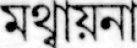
মথ্বায়না
